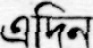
এদিন
